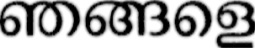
ഞങ്ങളെ
